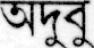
অদুবু
